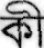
কী
